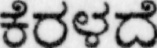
ಕೆರಳದೆ
